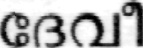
ദേവീ
